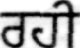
ਰਹੀ
